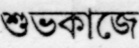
শুভকাজে
